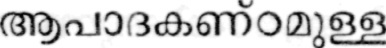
ആപാദകണ്ഠമുള്ള
